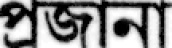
প্রজানা
